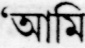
‘আমি
